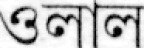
ওলাল
